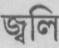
জ্বলি
